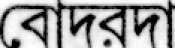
বোদরদা
